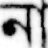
না
